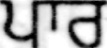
ਪਾਰ
